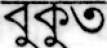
বুকুত
